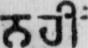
ਨਹੀਂ
